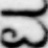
ವ
